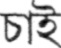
চাই
